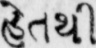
હેતથી
